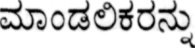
ಮಾಂಡಲಿಕರನ್ನು
